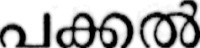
പക്കല്‍
